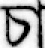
চা
